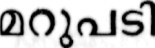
മറുപടി
